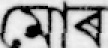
মোৰ
